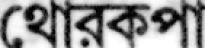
থোরকপা
